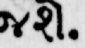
જશે.
